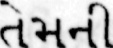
તેમની
